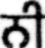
ਨੀ
